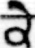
ਕੇ
